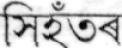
সিহঁতৰ
